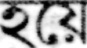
হয়ে
